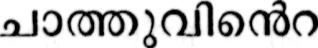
ചാത്തുവിന്റെ
